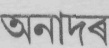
অনাদৰ
